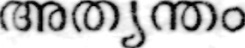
അത്യന്തം
